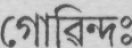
গোৱিন্দঃ
